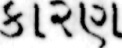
કારણ
